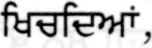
ਖਿਚਦਿਆਂ,
